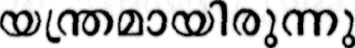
യന്ത്രമായിരുന്നു
